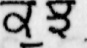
ਕੁਝ
